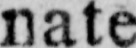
nate
